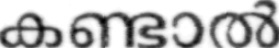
കണ്ടാല്‍
